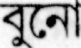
বুনো
